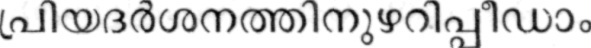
പ്രിയദര്‍ശനത്തിനുഴറിപ്പീഡാം
